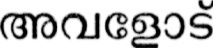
അവളോട്
